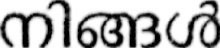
നിങ്ങള്‍
